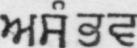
ਅਸੰਭਵ
